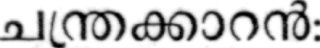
ചന്ത്രക്കാറന്‍:
